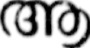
ആ
